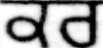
ਕਰ
